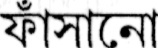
ফাঁসানো
